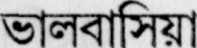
ভালবাসিয়া
